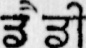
ਡੈਡੀ
